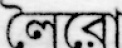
লৈরো
